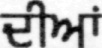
ਦੀਆਂ
